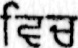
ਵਿਚ
